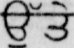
ਉੱਤੇ
